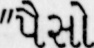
"પૈસો
